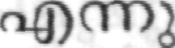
എന്നു
